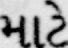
માટે
